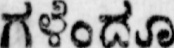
ಗಳೆಂದೂ
